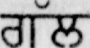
ਗੱਲ
